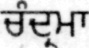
ਚੰਦ੍ਰਮਾ
